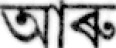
আৰু
